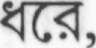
ধরে,
